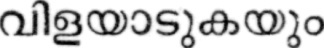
വിളയാടുകയും
